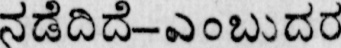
ನಡೆದಿದೆ-ಎಂಬುದರ
